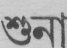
শুনা
